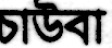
চাউবা
